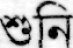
শুনি
